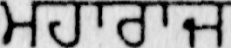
ਮਹਾਰਾਜ
